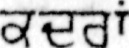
ਕਦਰਾਂ
